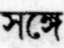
সঙ্গে
